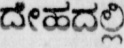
ದೇಹದಲ್ಲಿ
